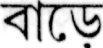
বাড়ে
